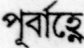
পূর্বাহ্ণে
